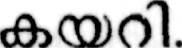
കയറി.
